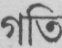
গতি
